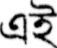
এই
